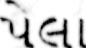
પેલા
